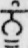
ਨੂੰ
